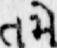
તમે
